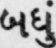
બધું
